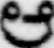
ಆ
